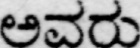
ಅವರು
